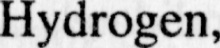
Hydrogen,
